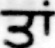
ਤਾਂ
